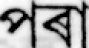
পৰা
